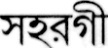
সহরগী
